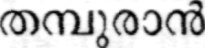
തമ്പുരാന്‍
